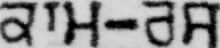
ਕਾਮ-ਰਸ
